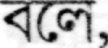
বলে,
